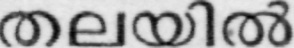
തലയില്‍
